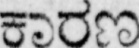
ಕಾರಣ
